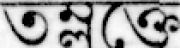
তম্লক্তে
